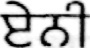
ਏਨੀ
